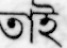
তাই
